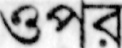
ওপর
